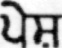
ਪੇਸ਼
